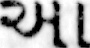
આ
